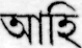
আহি
